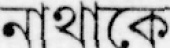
নাথাকে
